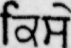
ਕਿਸੇ
